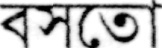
বসতো
